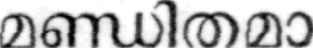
മണ്ഡിതമാ
